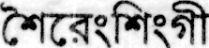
শৈরেংশিংগী
